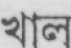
খাল
